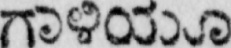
ಗಾಳಿಯೂ
